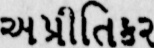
અપ્રીતિકર
